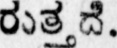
ರುತ್ತದೆ.
